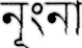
নূংনা
